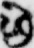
છે
